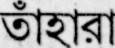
তাঁহারা
